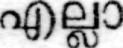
എല്ലാ
